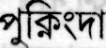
পুক্নিংদা
